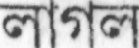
লাগল
